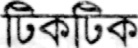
টিকটিক
